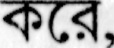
করে,
